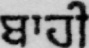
ਬਾਹੀ
